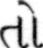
તો
